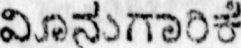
ಮೀನುಗಾರಿಕೆ
